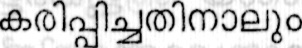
കരിപ്പിച്ചതിനാലും
